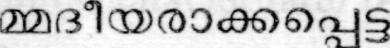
മ്മദീയരാക്കപ്പെട്ട
